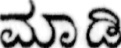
ಮಾಡಿ
